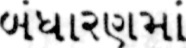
બંધારણમાં
